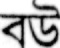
বউ
